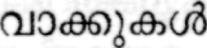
വാക്കുകള്‍
